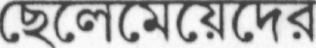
ছেলেমেয়েদের
